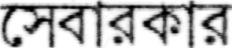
সেবারকার
